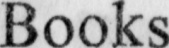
Books
